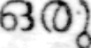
ഒരു
